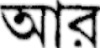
আর
